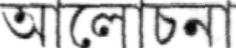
আলোচনা
